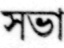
সভা
